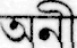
অনী
